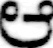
ಆ
